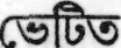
ভেটিত
